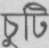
চুটি
